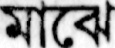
মাঝে
